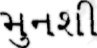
મુનશી
